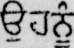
ਉਹਨੂੰ
